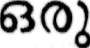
ഒരു
